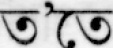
ত'তে
